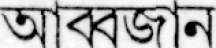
আব্বজান
